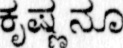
ಕೃಷ್ಣನೂ
